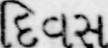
દિવસ
